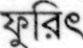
ফুরিৎ
